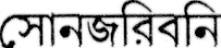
সোনজরিবনি
